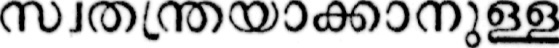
സ്വതന്ത്രയാക്കാനുള്ള
